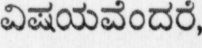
ವಿಷಯವೆಂದರೆ,
